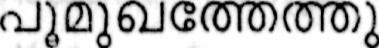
പുമുഖത്തേത്തു
